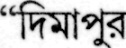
“দিমাপুর
